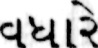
વધારે
